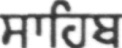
ਸਾਹਿਬ
